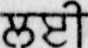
ਲਈ
